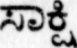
ಸಾಕ್ಷಿ
